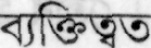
ব্যক্তিত্বত
